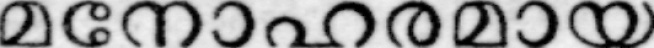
മനോഹരമായ
